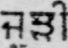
ਜੁੜੀ
